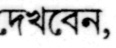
দেখবেন,
